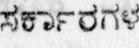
ಸರ್ಕಾರಗಳ
